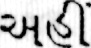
અહીં
